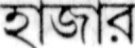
হাজার
